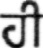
ਹੀ
